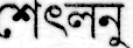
শেৎলনু
